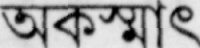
অকস্মাৎ
